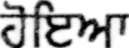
ਹੋਇਆ
